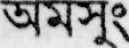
অমসুং
